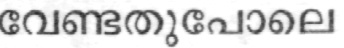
വേണ്ടതുപോലെ
